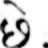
છે.
